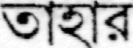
তাহার
